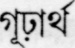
গূঢ়ার্থ
